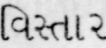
વિસ્તાર
